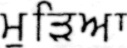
ਮੁੜਿਆ
